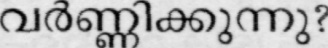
വര്‍ണ്ണിക്കുന്നു?
